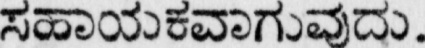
ಸಹಾಯಕವಾಗುವುದು.
